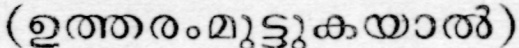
(ഉത്തരംമുട്ടുകയാല്‍)
